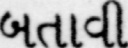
બતાવી
